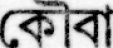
কৌবা
